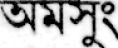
অমসুং
